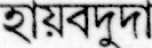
হায়বদুদা
